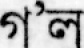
গ'ল
